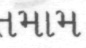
તમામ
